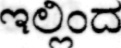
ಇಲ್ಲಿಂದ
